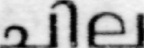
ചില
